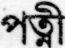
পত্নী
